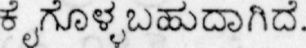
ಕೈಗೊಳ್ಳಬಹುದಾಗಿದೆ.
